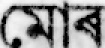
মোৰ
